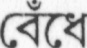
বেঁধে
